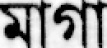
মাগা
